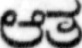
ಆತ
